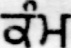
ਕੰਮ
